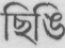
ছিঙি
